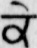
ਕੇ
